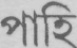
পাহি
